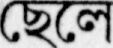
ছেলে
